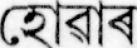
হোৱাৰ
